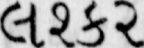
લશ્કર
